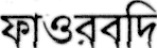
ফাওরবদি
